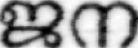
ജന
